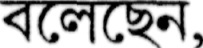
বলেছেন,
